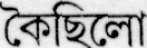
কৈছিলো
